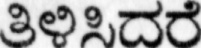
ತಿಳಿಸಿದರೆ
